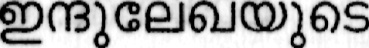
ഇന്ദുലേഖയുടെ
